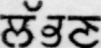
ਲੱਭਣ
